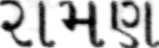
રામણ
